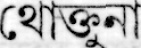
থোক্তুনা
